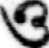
ও
